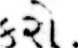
કરો.
